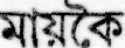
মায়কৈ
